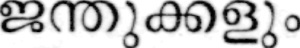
ജന്തുക്കളും
